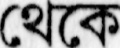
থেকে
